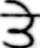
ਤੇ
